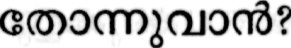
തോന്നുവാന്‍?
